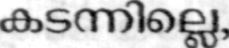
കടന്നില്ലെ,
